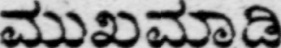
ಮುಖಮಾಡಿ
